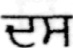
ਦਸ
